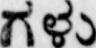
ಗಳು
